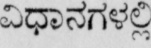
ವಿಧಾನಗಳಲ್ಲಿ
